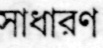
সাধারণ
